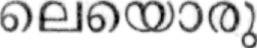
ലെയൊരു
